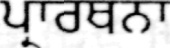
ਪ੍ਰਾਰਥਨਾ
